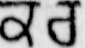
ਕਰ
